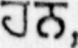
ਹਨ,
